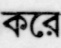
করে
